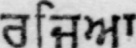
ਰਜਿਆ
